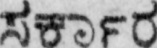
ಸರ್ಕಾರ
